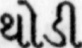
થોડી
